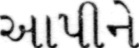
આપીને
